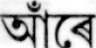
আঁৰে
